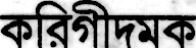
করিগীদমক
